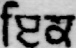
ਇਕ
